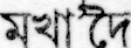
মখা’দৈ
